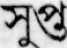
সুপ্ত
